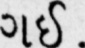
ગઈ.
